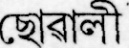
ছোৱালী
